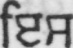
ਇਸ
